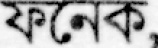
ফনেক,
